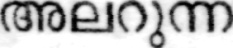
അലറുന്ന
